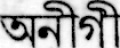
অনীগী
